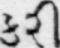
કરી
